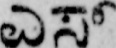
ಎಸ್
